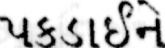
પકડાઈને
